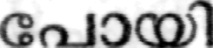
പോയി
